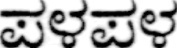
ಪಳಪಳ
